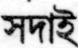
সদাই
